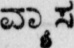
ವ್ಯಾಸ
